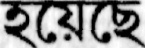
হয়েছে
